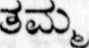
ತಮ್ಮ
